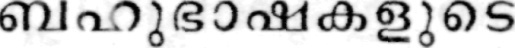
ബഹുഭാഷകളുടെ
